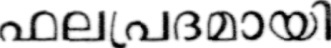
ഫലപ്രദമായി
